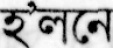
হ'লনে
